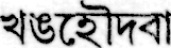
খঙহৌদবা
